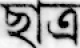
ছাত্র
